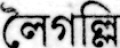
লৈগল্লি
